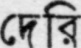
দেরি
